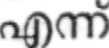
എന്ന്
